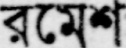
রমেশ
